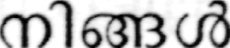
നിങ്ങള്‍
